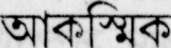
আকস্মিক
